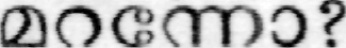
മറന്നോ?
